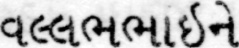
વલ્લભભાઈને
